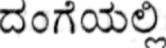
ದಂಗೆಯಲ್ಲಿ
